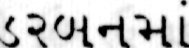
ડરબનમાં
